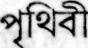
পৃথিবী
